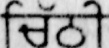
ਚਿੱਠੀ
